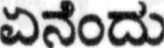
ಏನೆಂದು
